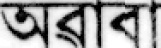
অৱাবা
